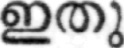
ഇതു
